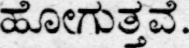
ಹೋಗುತ್ತವೆ.
